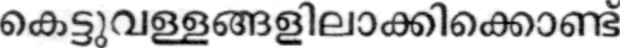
കെട്ടുവള്ളങ്ങളിലാക്കിക്കൊണ്ട്
